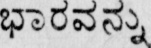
ಭಾರವನ್ನು
